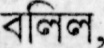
বলিল,
